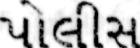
પોલીસ
